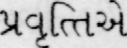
પ્રવૃત્તિએ
